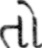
તો
